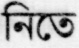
নিতে
